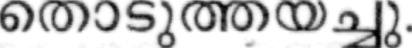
തൊടുത്തയച്ചു.
